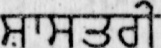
ਸ਼ਾਸਤਰੀ
